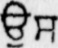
ਉਸ
